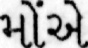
મોંએ
